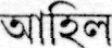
আহিল
